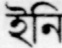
ইনি
